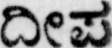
ದೀಪ
